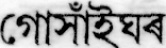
গোসাঁইঘৰ
